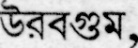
উরবগুম,
